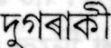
দুগৰাকী
